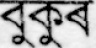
বুকুৰ
